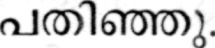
പതിഞ്ഞു.
